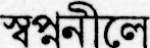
স্বপ্ননীলে
